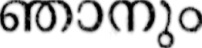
ഞാനും
